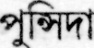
পুন্সিদা
